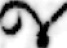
જ
